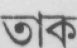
তাক
